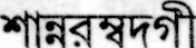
শান্নরম্বদগী
